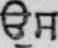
ਉਸ
